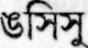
ঙসিসু
